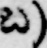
ಬ)
